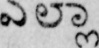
ಎಲ್ಲಾ
